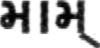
મામ્
